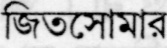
জিতসোমার
